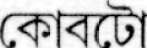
কোবটো
